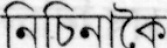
নিচিনাকৈ
